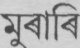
মুৰাৰি
